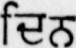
ਦਿਨ
